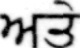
ਅਤੇ
